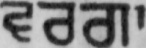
ਵਰਗਾ
